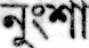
নুংশা
